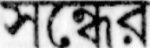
সন্ধের
